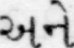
અને
